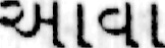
આવા
